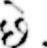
છે.
